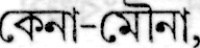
কেনা-মৌনা,
